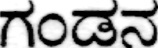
ಗಂಡನ
